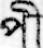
পী
